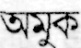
অমুক
